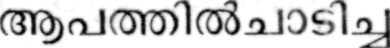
ആപത്തില്‍ചാടിച്ച
